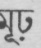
মূঢ়
